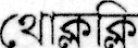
থোক্লক্লি
